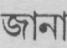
জানা
